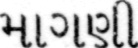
માગણી
